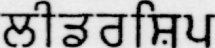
ਲੀਡਰਸ਼ਿਪ
